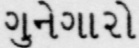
ગુનેગારો
